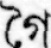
গৈ
